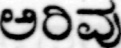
ಅರಿವು
